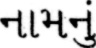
નામનું
